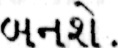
બનશે.
